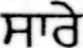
ਸਾਰੇ
